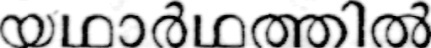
യഥാര്‍ഥത്തില്‍
